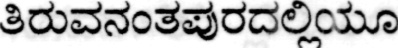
ತಿರುವನಂತಪುರದಲ್ಲಿಯೂ
